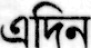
এদিন
